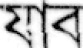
যাব
